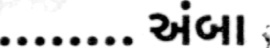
...........અંબા
